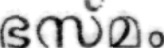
ഭസ്മം
